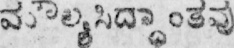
ಮೌಲ್ಯಸಿದ್ದಾಂತವು
